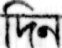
দিন
